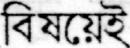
বিষয়েই
